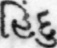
હિંદુ
